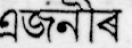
এজনীৰ
